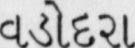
વડોદરા
